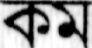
কম
